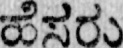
ಹೆಸರು
